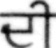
ਦੀ
